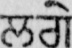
ਲਗੇ
